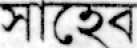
সাহেব
